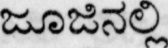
ಜೂಜಿನಲ್ಲಿ
